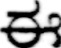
ಈ
